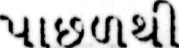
પાછળથી
